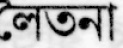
লৈতনা
